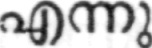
എന്നു
